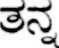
ತನ್ನ
